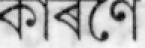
কাৰণে
